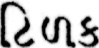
ટિળક
